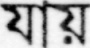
যায়
